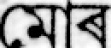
মোৰ
